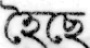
হৈছে
